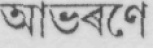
আভৰণে
